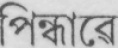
পিন্ধাৱে
